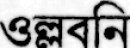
ওল্লবনি
